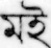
মই
